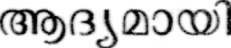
ആദ്യമായി
